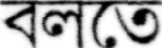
বলতে
